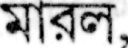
মারল,
